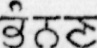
ਭੰਨਣ
